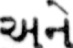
અને
